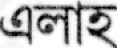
এলাহ
